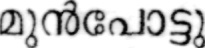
മുന്‍പോട്ടു
